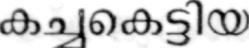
കച്ചകെട്ടിയ
